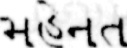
મહેનત
